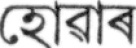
হোৱাৰ
